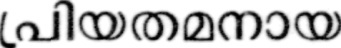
പ്രിയതമനായ
